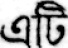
এটি
